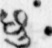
છું.
